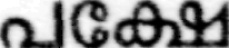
പക്ഷേ
